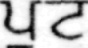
ਪੁਟ
